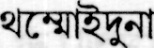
থম্মোইদুনা
